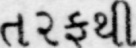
તરફથી
